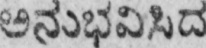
ಅನುಭವಿಸಿದ
